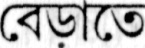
বেড়াতে
